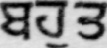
ਬਹੁਤ
